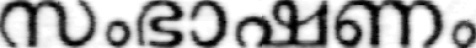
സംഭാഷണം
